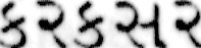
કરકસર
